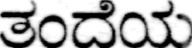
ತಂದೆಯ
